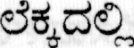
ಲೆಕ್ಕದಲ್ಲಿ
